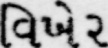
વિખેર
